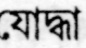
যোদ্ধা
